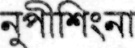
নুপীশিংনা
